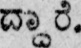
ದ್ದಾರೆ.
